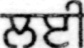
ਲਈ
